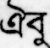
ঐবু
